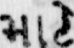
માટે
